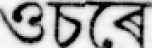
ওচৰে
